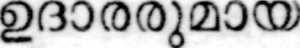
ഉദാരരുമായ
